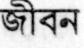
জীবন
